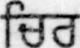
ਚਿਰ
